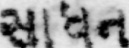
સાધન
